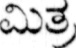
ಮಿತ್ರ
